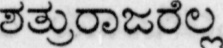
ಶತ್ರುರಾಜರೆಲ್ಲ
